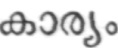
കാര്യം
